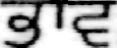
ਭਾਵ
